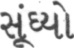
સૂંઘ્યો
